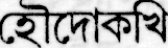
হৌদোকখি
